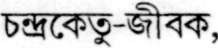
চন্দ্রকেতু-জীবক,
